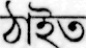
ঠাইত
